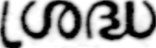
ശ്രദ്ധ
